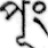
পূং
